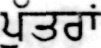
ਪੁੱਤਰਾਂ
